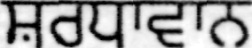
ਸ਼ਰਧਾਵਾਨ
